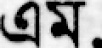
এম.
